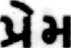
પ્રેમ
